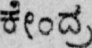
ಕೇಂದ್ರ
